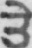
ਤੇ
